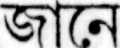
জানে
